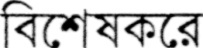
বিশেষকরে
